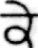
ਕੇ
